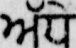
ਅੱਧੇ
